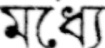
মধ্যে
